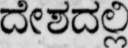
ದೇಶದಲ್ಲಿ
